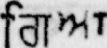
ਗਿਆ
